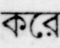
করে
